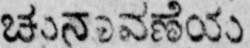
ಚುನಾವಣೆಯ
